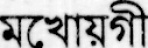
মখোয়গী
